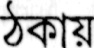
ঠকায়
